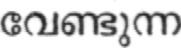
വേണ്ടുന്ന
